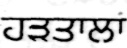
ਹੜਤਾਲਾਂ
